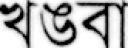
খঙবা
